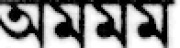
অমমম
